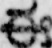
ಈ
